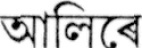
আলিৰে
